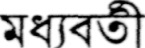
মধ্যবর্তী
